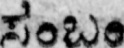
ಸಂಬಂ
